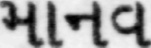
માનવ
